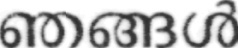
ഞങ്ങള്‍
